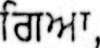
ਗਿਆ,
